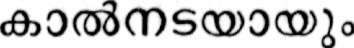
കാല്‍നടയായും
